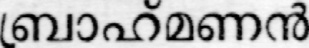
ബ്രാഹ്മണന്‍
